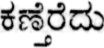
ಕಣ್ತೆರೆದು
